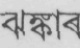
ঝঙ্কাৰ
